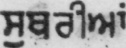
ਸੁਥਰੀਆਂ
